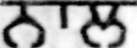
ਨਾਲ
